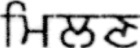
ਮਿਲਣ
